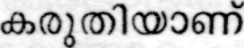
കരുതിയാണ്
